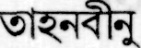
তাহনবীনু
